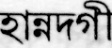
হান্নদগী
